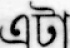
এটা
